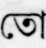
তো
